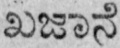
ಖಜಾನೆ
